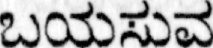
ಬಯಸುವ
